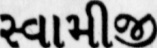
સ્વામીજી
